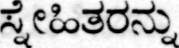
ಸ್ನೇಹಿತರನ್ನು
